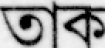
তাক
